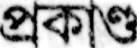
প্রকাণ্ড
